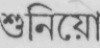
শুনিয়ো
